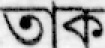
তাক
